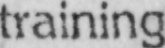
training
